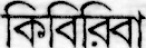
কিবিরিবা
